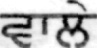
ਵਾਲੇ
